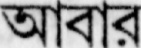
আবার
